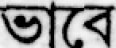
ভাবে
